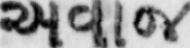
અવાજ
